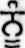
ਨੂੰ
